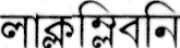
লাক্লম্লিবনি
